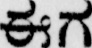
ಈಗ
